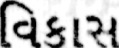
વિકાસ
